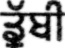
ਡੁੱਬੀ
